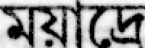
ময়াদ্রে
